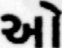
ઓ
